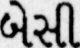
બેસી
